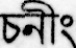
চনীং
